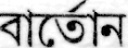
বার্তোন
